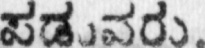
ಪಡುವರು.
